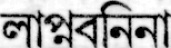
লাপ্নবনিনা
